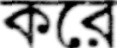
করে
